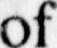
of
